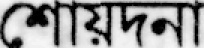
শোয়দনা
